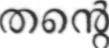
തന്റെ
